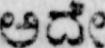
ಅದೇ
